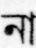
না
